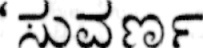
'ಸುವರ್ಣ
